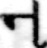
ન
